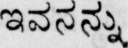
ಇವನನ್ನು
